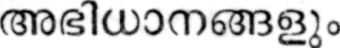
അഭിധാനങ്ങളും
